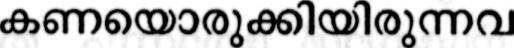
കണയൊരുക്കിയിരുന്നവ
